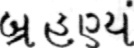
બ્રહણ્યં
